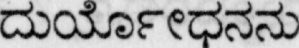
ದುರ್ಯೋಧನನು
